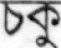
চকু
